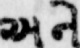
અને
